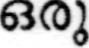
ഒരു
